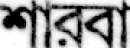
শারবা
